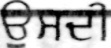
ਉਸਦੀ
